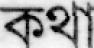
কথা
